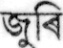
জুৰি
